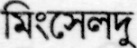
মিংসেলদু
